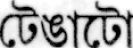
টেঙাটো
